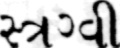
સ્ત્રગ્વી
